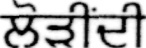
ਲੋੜੀਂਦੀ
